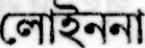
লোইননা
